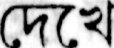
দেখে
